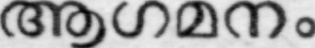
ആഗമനം
